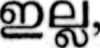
ഇല്ല,
